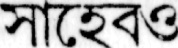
সাহেবও
